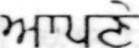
ਆਪਣੇ
